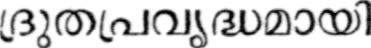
ദ്രുതപ്രവൃദ്ധമായി
